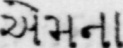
એમના
